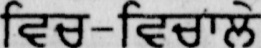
ਵਿਚ-ਵਿਚਾਲੇ
